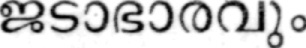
ജടാഭാരവും
